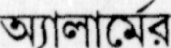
অ্যালার্মের
